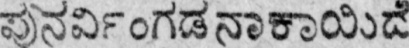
ಪುನರ್ವಿಂಗಡನಾಕಾಯಿದೆ
